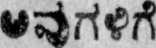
ಅವುಗಳಿಗೆ
